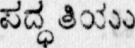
ಪದ್ಧತಿಯು
